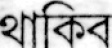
থাকিব
